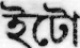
ইটো
